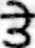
ਤੇ
